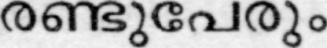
രണ്ടുപേരും
